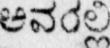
ಅವರಲ್ಲಿ
